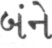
બંને
